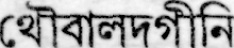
থৌবালদগীনি
